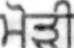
ਮੋੜੀ
